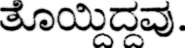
ತೊಯ್ದಿದ್ದವು.
